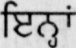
ਇਨ੍ਹਾਂ
